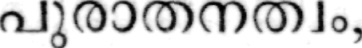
പുരാതനത്വം,
